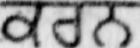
ਕਰਨ
